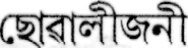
ছোৱালীজনী
